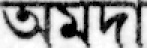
অমদা
